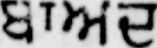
ਬਾਅਦ
